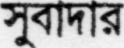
সুবাদার
